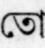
তো
